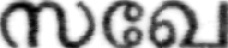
സഖേ
